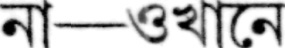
না–ওখানে
